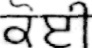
ਕੋਈ
